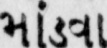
માંડવા
